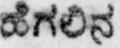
ಹೆಗಲಿನ
